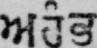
ਅਹੰਭ
